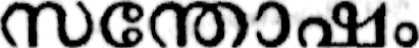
സന്തോഷം
